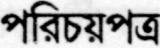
পরিচয়পত্র
